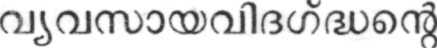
വ്യവസായവിദഗ്ദ്ധന്റെ
